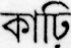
কাঢ়ি
